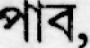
পাব,
